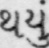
થયું
